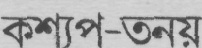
কশ্যপ-তনয়
